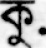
কু.
